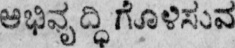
ಅಭಿವೃದ್ಧಿಗೊಳಿಸುವ
